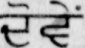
ਦੋਵੇਂ
